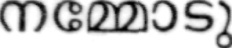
നമ്മോടു
